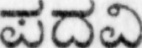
ಪದವಿ
